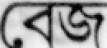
বেজ
